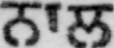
ਨਾਲ
